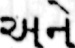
અને
